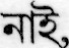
নাই,
